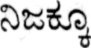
ನಿಜಕ್ಕೂ
